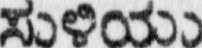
ಸುಳಿಯು
